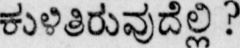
ಕುಳಿತಿರುವುದೆಲ್ಲಿ?
